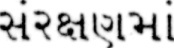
સંરક્ષણમાં
